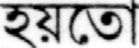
হয়তো
